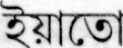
ইয়াতো
